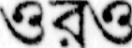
ওরও
